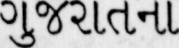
ગુજરાતના
